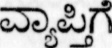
ವ್ಯಾಪ್ತಿಗೆ
